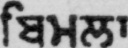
ਬਿਮਲਾ
